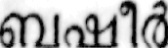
ബഷീര്‍
